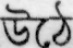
উঠে
